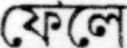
ফেলে
